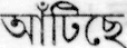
আঁটিছে
